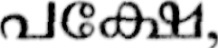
പക്ഷേ,
